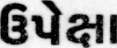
ઉપેક્ષા
